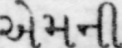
એમની
